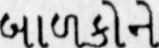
બાળકોને
